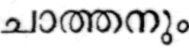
ചാത്തനും
